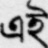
এই
